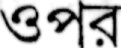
ওপর
